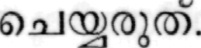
ചെയ്യരുത്.
